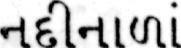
નદીનાળાં
